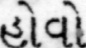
હોવો
